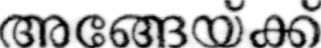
അങ്ങേയ്ക്ക്
